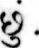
છું.
